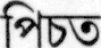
পিচত
